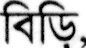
বিড়ি,
